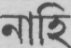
নাহি
